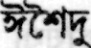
ঈশৈদু
